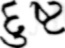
દુષ્ટ
